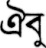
ঐবু
